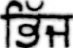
ਭਿੱਜ
